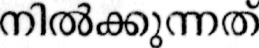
നില്‍ക്കുന്നത്
